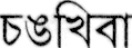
চঙখিবা
